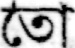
তো
